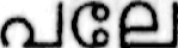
പലേ
